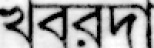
খবরদা
